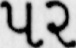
પર
